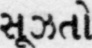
સૂઝતો
